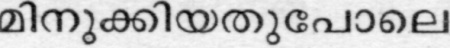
മിനുക്കിയതുപോലെ
